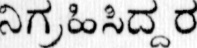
ನಿಗ್ರಹಿಸಿದ್ದರ
